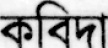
কবিদা
